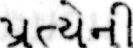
પ્રત્યેની
